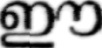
ഈ
